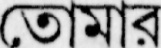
তোমার
